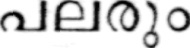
പലരും
